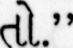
તો."
